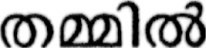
തമ്മില്‍
